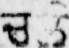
ਚਲੇ
